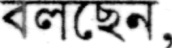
বলছেন,
